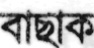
বাছাক
